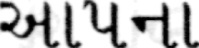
આપના
